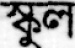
স্কুল
